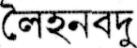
লৈহনবদু
